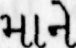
માને
